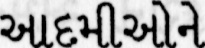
આદમીઓને
